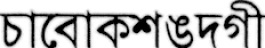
চাবোকশঙদগী
